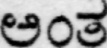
ಅಂತ
